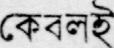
কেবলই
